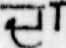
ਦਾ
